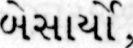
બેસાર્યો,
